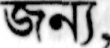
জন্য,
